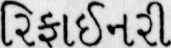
રિફાઈનરી
